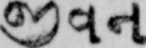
જીવન
